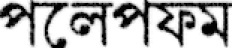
পলেপফম
